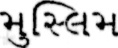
મુસ્લિમ
